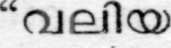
"വലിയ
